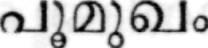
പൂമുഖം
